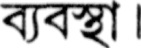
ব্যবস্থা।
